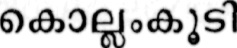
കൊല്ലംകൂടി
